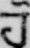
ਹੋ
